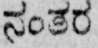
ನಂತರ
